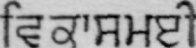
ਵਿਕਾਸਮਈ
